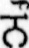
ਨੌ
